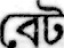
বেট
